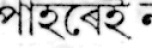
পাহৰেই
